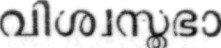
വിശ്വസ്തഭാ
